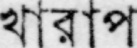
খারাপ
